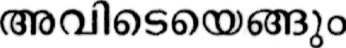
അവിടെയെങ്ങും
